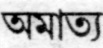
অমাত্য
